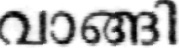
വാങ്ങി
